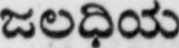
ಜಲಧಿಯ
